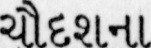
ચૌદશના
